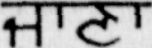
ਜਾਣਾ
